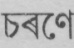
চৰণে
